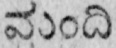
ಮಂದಿ
